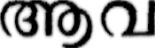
ആവ
